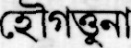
হৌগত্তুনা
